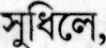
সুধিলে,
